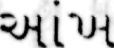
આંખ
